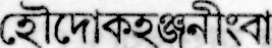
হৌদোকহঞ্জনীংবা
